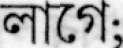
লাগে;
